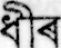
ধীৰ
